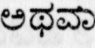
ಅಥವಾ
